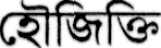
হৌজিক্তি
